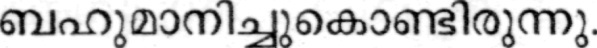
ബഹുമാനിച്ചുകൊണ്ടിരുന്നു.
